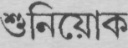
শুনিয়োক
